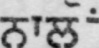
ਨਾਲੋਂ
